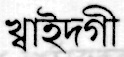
খ্বাইদগী
